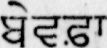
ਬੇਵਫ਼ਾ
